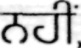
ਨਹੀਂ,
